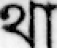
থা
